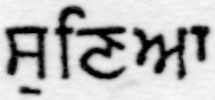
ਸੁਣਿਆ
